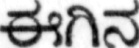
ಈಗಿನ
